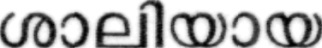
ശാലിയായ
